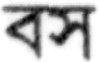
বস
